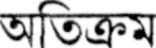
অতিক্রম
